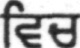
ਵਿਚ
